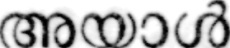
അയാള്‍
